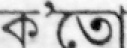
ক'তো
